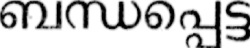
ബന്ധപ്പെട്ട
